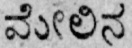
ಮೇಲಿನ
